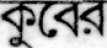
কুবের
